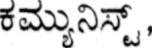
ಕಮ್ಯುನಿಸ್ಟ್,
